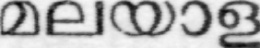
മലയാള
